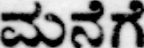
ಮನೆಗೆ
